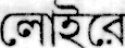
লোইরে
